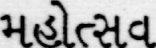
મહોત્સવ
